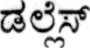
ಡಲ್ಲೆಸ್
